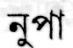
নুপা
